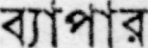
ব্যাপার
